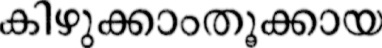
കിഴുക്കാംതൂക്കായ
